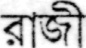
রাজী
